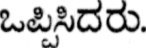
ಒಪ್ಪಿಸಿದರು.
